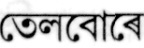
তেলবোৰে
